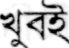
খুবই
